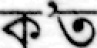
ক'ত
